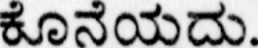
ಕೊನೆಯದು.
